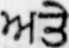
ਅਤੇ
